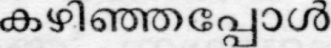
കഴിഞ്ഞപ്പോള്‍
